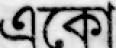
একো
